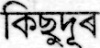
কিছুদূৰ
